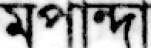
মপান্দা
